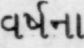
વર્ષના
